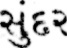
સુંદર
